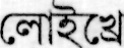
লোইখ্রে
